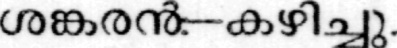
ശങ്കരന്‍:-കഴിച്ചു.
